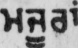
ਮਜੂਰਾਂ
